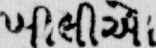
ખીલીઓ
